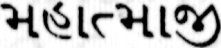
મહાત્માજી
